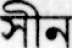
সীন
